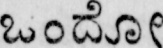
ಒಂದೋ
